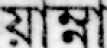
য়াম্না
